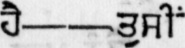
ਹੈ------ਤੁਸੀਂ
